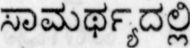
ಸಾಮರ್ಥ್ಯದಲ್ಲಿ
